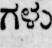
ಗಳು
